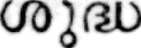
ശുദ്ധ
